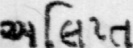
અલપ્તિ
